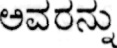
ಅವರನ್ನು
